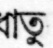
ধাতু
